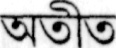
অতীত
